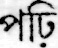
পঢ়ি
